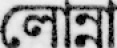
লোন্না
